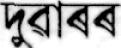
দুৱাৰৰ
